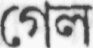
গেল
